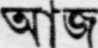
আজ
